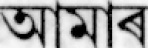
আমাৰ
